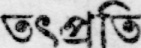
তৎপ্রতি
